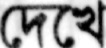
দেখে
